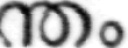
ന്തം
